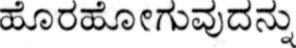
ಹೊರಹೋಗುವುದನ್ನು
